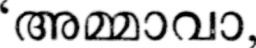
'അമ്മാവാ,
